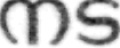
നട
